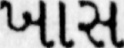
ખાસ
